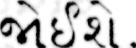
જોઇશે.
